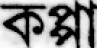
কপ্পা
